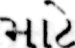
માટે
